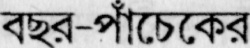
বছর-পাঁচেকের
